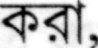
করা,
